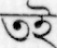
তই
